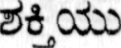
ಶಕ್ತಿಯು
